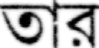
তার
